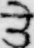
ਤੇ
